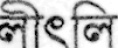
লীৎলি
